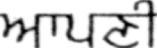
ਆਪਣੀ
